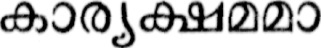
കാര്യക്ഷമമാ
